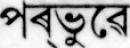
পৰ্‌ভুৱে
